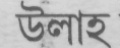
উলাহ
